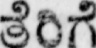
ತೆರಿಗೆ
